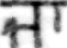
ਜਾ
